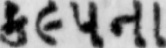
કલ્પના
